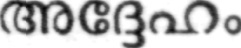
അദ്ദേഹം
